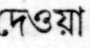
দেওয়া
